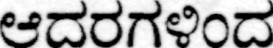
ಆದರಗಳಿಂದ
